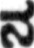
ನ
